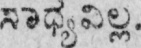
ಸಾಧ್ಯವಿಲ್ಲ.
